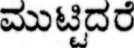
ಮುಟ್ಟಿದರೆ
